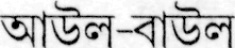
আউল-বাউল
